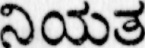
ನಿಯತ
